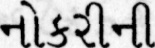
નોકરીની
